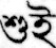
শুই
